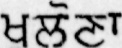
ਖਲੋਣਾ
